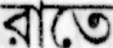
রাতে
